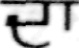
ਦਾ
